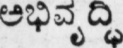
ಅಭಿವೃದ್ಧಿ
